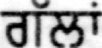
ਗੱਲਾਂ
